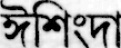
ঈশিংদা
